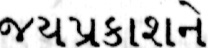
જયપ્રકાશને
